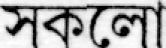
সকলো
